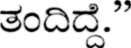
ತಂದಿದ್ದೆ."
